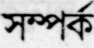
সম্পর্ক
